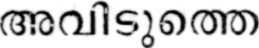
അവിടുത്തെ
